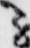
કે
